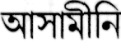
আসামীনি
